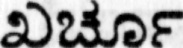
ಖರ್ಚೂ
